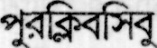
পুরক্লিবসিবু
